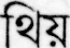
থিয়
